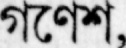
গণেশ,
